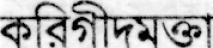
করিগীদমক্তা
